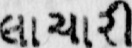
લાચારી
